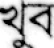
খুব
